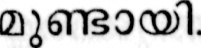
മുണ്ടായി.
